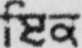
ਇਕ
